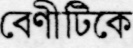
বেণীটিকে
